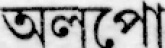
অলপো
